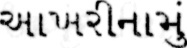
આખરીનામું
